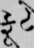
ફૂટે
